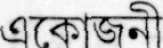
একোজনী
